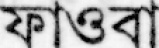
ফাওবা
